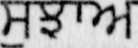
ਸੁਝਾਅ
